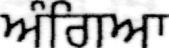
ਅੰਗਿਆ
